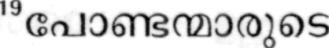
19പോണ്ടന്മാരുടെ
